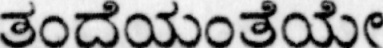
ತಂದೆಯಂತೆಯೇ
